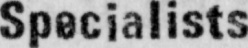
Spaciallists
